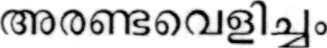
അരണ്ടവെളിച്ചം
